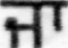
ਜਾ
